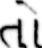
તો
